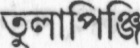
তুলাপিঞ্জি
